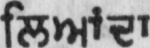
ਲਿਆਂਦਾ
